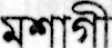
মশাগী
